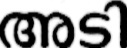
അടി
